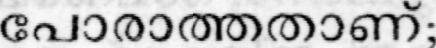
പോരാത്തതാണ്;
